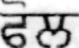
ਫੋਲ
